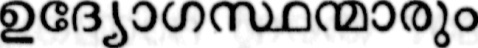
ഉദ്യോഗസ്ഥന്മാരും
